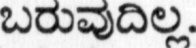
ಬರುವುದಿಲ್ಲ.
